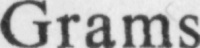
Grams
